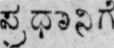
ಪ್ರಧಾನಿಗೆ
